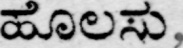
ಹೊಲಸು,
